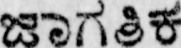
ಜಾಗತಿಕ
